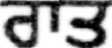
ਰਾਤ
